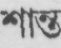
শান্ত
